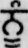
ਨੂੰ
